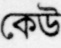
কেউ
